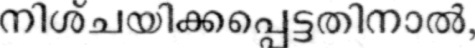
നിശ്ചയിക്കപ്പെട്ടതിനാല്‍,
